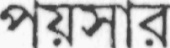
পয়সার
